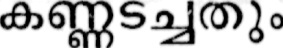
കണ്ണടച്ചതും
